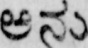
ಅನು
